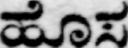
ಹೊಸ
